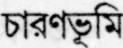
চারণভূমি
